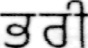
ਭਰੀ
